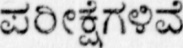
ಪರೀಕ್ಷೆಗಳಿವೆ
